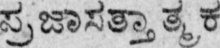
ಪ್ರಜಾಸತ್ತಾತ್ಮಕ
